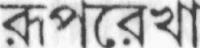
রূপরেখা
